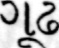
ગૂઢ
